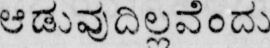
ಆಡುವುದಿಲ್ಲವೆಂದು
